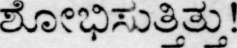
ಶೋಭಿಸುತ್ತಿತ್ತು!
